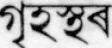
গৃহস্থৰ
